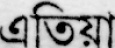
এতিয়া
